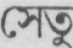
সেতু
